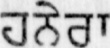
ਹਨੇਰਾ
